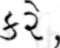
કરે,
